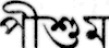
পীশু
